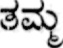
ತಮ್ಮ
